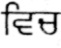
ਵਿਚ
